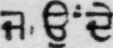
ਜੀਉਂਦੇ
